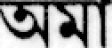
অমা
